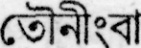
তৌনীংবা
